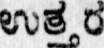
ಉತ್ತರ
